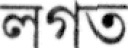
লগত
